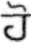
ਹੋ
